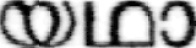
യഥാ
